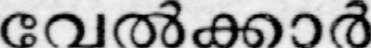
വേല്‍ക്കാര്‍
